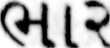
ભાર
